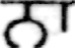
ਨਾ
